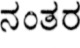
ನಂತರ
